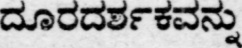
ದೂರದರ್ಶಕವನ್ನು
